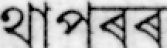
থাপৰৰ
